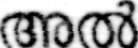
അല്‍
